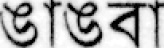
ঙাঙবা
